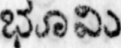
ಭೂಮಿ
